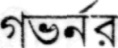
গভর্নর
